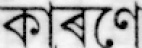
কাৰণে
